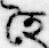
হৈ
